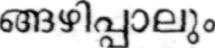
ങ്ങഴിപ്പാലും
